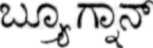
ಬ್ರ್ಯೂಗ್ನಾನ್
